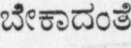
ಬೇಕಾದಂತೆ
